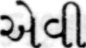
એવી
